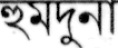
হুমদুনা
